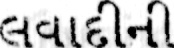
લવાદીની
